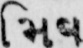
મિવ
